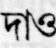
দাও
